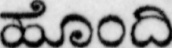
ಹೊಂದಿ
